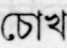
চোখ
